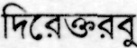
দিরেক্তরবু
